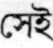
সেই
